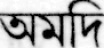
অমদি
